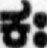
ಕಃ
